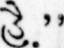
હૈ."
